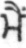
ਮੈਂ
